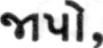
જાપો,
